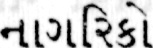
નાગરિકો
